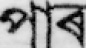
পাৰ
